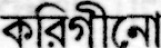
করিগীনো
